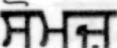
ਸੋਮਜ਼
